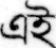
এই
